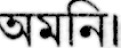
অমনি।
